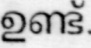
ഉണ്ട്.
